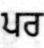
ਪਰ
